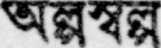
অল্পস্বল্প
